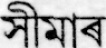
সীমাৰ
